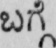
ಬಗ್ಗೆ
